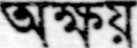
অক্ষয়
